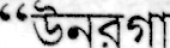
“উনরগা
